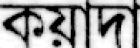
কয়াদা
